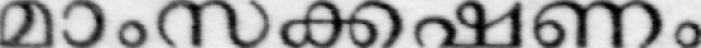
മാംസക്കഷണം
